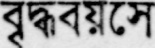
বৃদ্ধবয়সে
